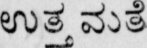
ಉತ್ತಮತೆ
